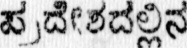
ಪ್ರದೇಶದಲ್ಲಿನ
